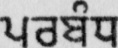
ਪਰਬੰਧ
